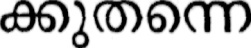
ക്കുതന്നെ
